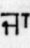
ਜਾ
